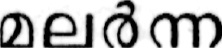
മലര്‍ന്ന
